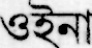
ওইনা
